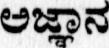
ಅಜ್ಞಾನ
